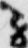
કે
